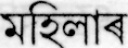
মহিলাৰ
